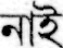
নাই
